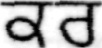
ਕਰ
